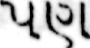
પણ
